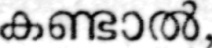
കണ്ടാല്‍,
